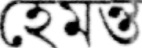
হেমন্ত
